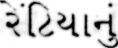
રેંટિયાનું
